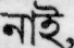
নাই,
